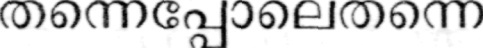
തന്നെപ്പോലെതന്നെ
